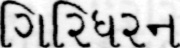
ગિરિધરન
